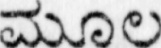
ಮೂಲ
